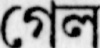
গেল
